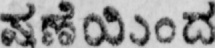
ಷಣೆಯಿಂದ
